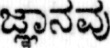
ಜ್ಞಾನವು
